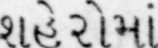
શહેરોમાં
